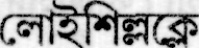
লোইশিল্লক্লে
